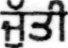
ਜੁੱਤੀ
